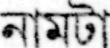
নামটা
